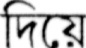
দিয়ে
